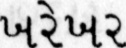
ખરેખર
